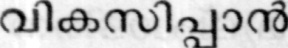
വികസിപ്പാന്‍
